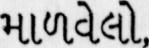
માળવેલો,
